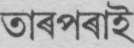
তাৰপৰাই
